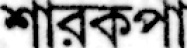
শারকপা
